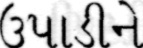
ઉપાડીને
